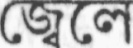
জ্বেলে
